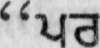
''ਪਰ
